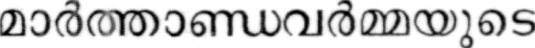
മാര്‍ത്താണ്ഡവര്‍മ്മയുടെ
